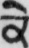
ਕੇ
